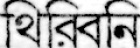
থিরিবনি
